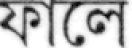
ফালে
